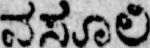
ವಸೂಲಿ
